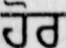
ਹੋਰ
